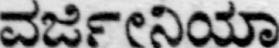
ವರ್ಜೀನಿಯಾ
